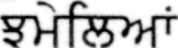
ਝਮੇਲਿਆਂ
